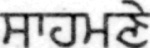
ਸਾਹਮਣੇ
